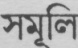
সমূলি
